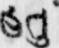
હતું
